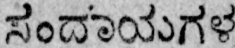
ಸಂದಾಯಗಳ
